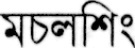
মচলশিং
